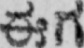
ಈಗ
